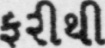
ફરીથી
